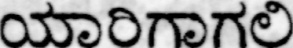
ಯಾರಿಗಾಗಲಿ
